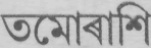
তমোৰাশি
